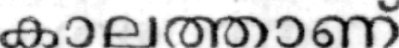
കാലത്താണ്
